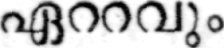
ഏററവും
